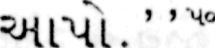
આપો."૫૦
